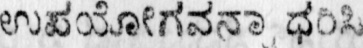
ಉಪಯೋಗವನ್ನಾಧರಿಸಿ
